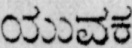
ಯುವಕ
